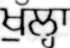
ਖੁੱਲ੍ਹਾ
